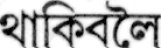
থাকিবলৈ
